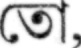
তো,
